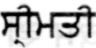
ਸ੍ਰੀਮਤੀ
